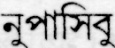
নুপাসিবু
